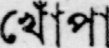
খোঁপা
